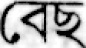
বেছ
